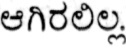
ಆಗಿರಲಿಲ್ಲ.
